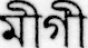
মীগী
